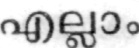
എല്ലാം
